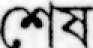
শেষ
